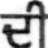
ਦੀ
